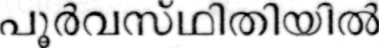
പൂര്‍വസ്ഥിതിയില്‍
